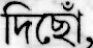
দিছোঁ,
